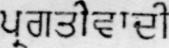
ਪ੍ਰਗਤੀਵਾਦੀ
